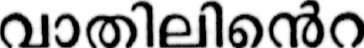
വാതിലിന്റെ
